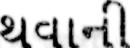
થવાની
